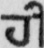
ਹੀ
